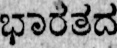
ಭಾರತದ
